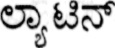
ಲ್ಯಾಟಿನ್
